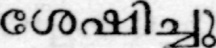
ശേഷിച്ചു
